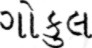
ગોકુલ
